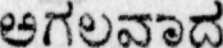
ಅಗಲವಾದ
